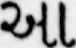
આ
